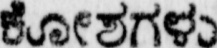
ಕೋಶಗಳು
